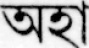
অহা
